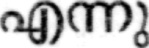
എന്നു
